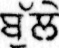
ਬੁੱਲੇ
